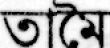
তামৈ
